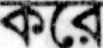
করে
